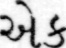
એક
